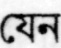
যেন
